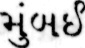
મુંબઈ
